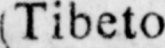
(Tibeto
